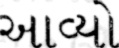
આવ્યો
